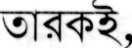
তারকই,
